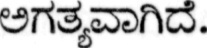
ಅಗತ್ಯವಾಗಿದೆ.
